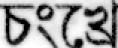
চংখ্রে
